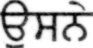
ਉਸਨੇ
